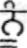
ਨੂੰ
